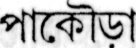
পাকৌড়া
